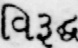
વિરૂદ્ધ
